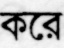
করে
